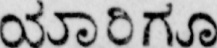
ಯಾರಿಗೂ
